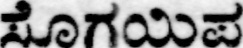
ಸೊಗಯಿಪ
